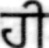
ਹੀ
